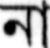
না
